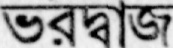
ভরদ্বাজ
